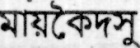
মায়কৈদসু
